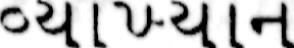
વ્યાખ્યાન
